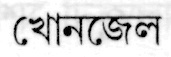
খোনজেল
